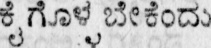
ಕೈಗೊಳ್ಳಬೇಕೆಂದು
